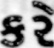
કરે
